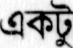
একটু
